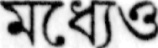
মধ্যেও
